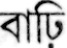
বাঢ়ি
